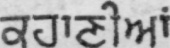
ਕਹਾਣੀਆਂ
